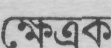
ক্ষেত্ৰক
